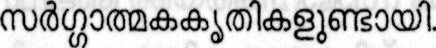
സര്‍ഗ്ഗാത്മകകൃതികളുണ്ടായി.
